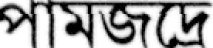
পামজদ্রে
